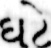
ઘટે
